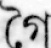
গৈ
